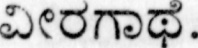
ವೀರಗಾಥೆ.
